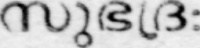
സുഭദ്ര:
